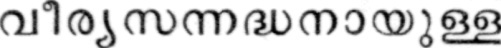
വീര്യസന്നദ്ധനായുള്ള
